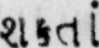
શકતાં
